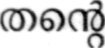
തന്റെ
